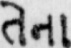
તેના
